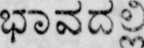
ಭಾವದಲ್ಲಿ
